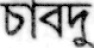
চাবদু
